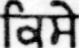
ਕਿਸੇ
